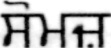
ਸੋਮਜ਼
